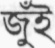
জুঁই
